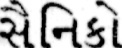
સૈનિકો
